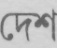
দেশ
